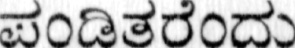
ಪಂಡಿತರೆಂದು
